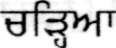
ਚੜ੍ਹਿਆ
